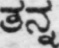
ತನ್ನ
